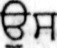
ਉਸ
